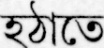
হঠাতে
